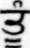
ਤੂੰ
